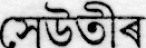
সেউতীৰ
